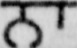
ਨਾ
